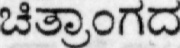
ಚಿತ್ರಾಂಗದ
